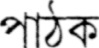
পাঠক
